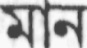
মান
